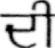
ਦੀ
